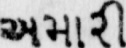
અમારી
